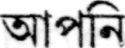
আপনি
